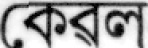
কেৱল
